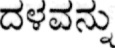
ದಳವನ್ನು
